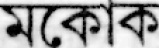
মকোক
